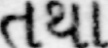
તથા
